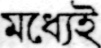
মধ্যেই
